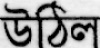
উঠিল
